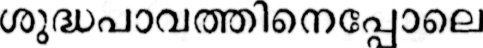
ശുദ്ധപാവത്തിനെപ്പോലെ
